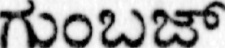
ಗುಂಬಜ್
